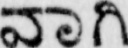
ವಾಗಿ
